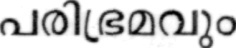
പരിഭ്രമവും
